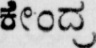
ಕೇಂದ್ರ
